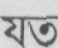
যত
